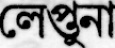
লেপ্তুনা
